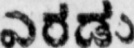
ಎರಡು
